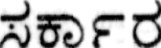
ಸರ್ಕಾರ
